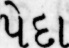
પેદા
